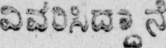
ವಿವರಿಸಿದ್ದಾನೆ
